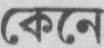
কেনে
